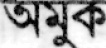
অমুক
